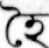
হৈ
